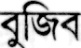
বুজিব
